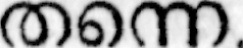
തന്നെ.
